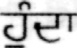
ਹੁੰਦਾ
